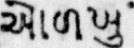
ઓળખું
